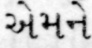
એમને
